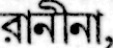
রানীনা,
